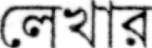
লেখার
